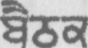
ਬੈਠਕ
